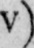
v)
